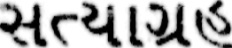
સત્યાગ્રહ
